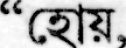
“হোয়,
